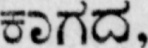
ಕಾಗದ,
